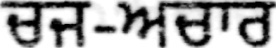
ਚਜ-ਅਚਾਰ
